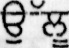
ਉੱਲੂ
